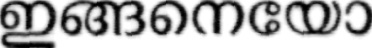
ഇങ്ങനെയോ
